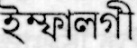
ইম্ফালগী
